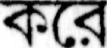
করে
